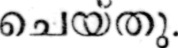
ചെയ്തു.
